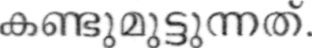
കണ്ടുമുട്ടുന്നത്.
